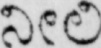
ನೀಲಿ
